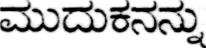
ಮುದುಕನನ್ನು
